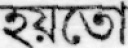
হয়তো
